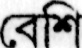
বেশি
